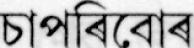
চাপৰিবোৰ
